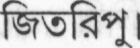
জিতরিপু।
